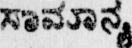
ಸಾಮಾನ್ಯ
